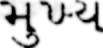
મુખ્ય
